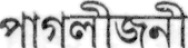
পাগলীজনী
